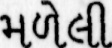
મળેલી
